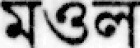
মওল
